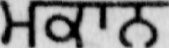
ਮਕਾਨ
